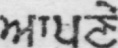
ਆਪਣੇ
